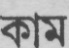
কাম
